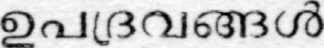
ഉപദ്രവങ്ങള്‍
